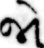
જો
